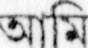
আমি
